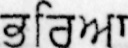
ਭਰਿਆ
